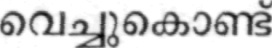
വെച്ചുകൊണ്ട്
